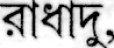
রাধাদু,
